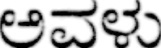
ಅವಳು
